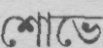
শোভে
